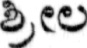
ಶ್ರೀಲ
